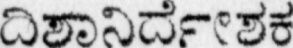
ದಿಶಾನಿರ್ದೇಶಕ
